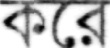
করে
